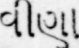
વીણા
